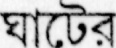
ঘাটের
